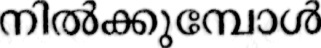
നില്‍ക്കുമ്പോള്‍
